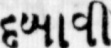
દબાવી
